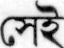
সেই
